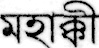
মহাক্কী
